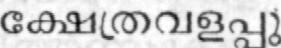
ക്ഷേത്രവളപ്പു
